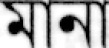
মানা
